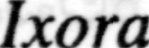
Ixora
